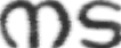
നട
